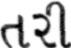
તરી
